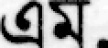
এম.
